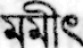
মমীৎ
